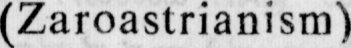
(Zaroastrianism)
